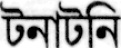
টনাটনি
